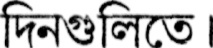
দিনগুলিতে।
